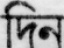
দিন
